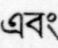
এবং
